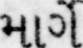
માર્ગે
